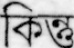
কিন্তু
